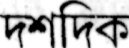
দশদিক
